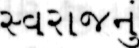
સ્વરાજનું
